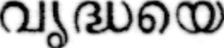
വൃദ്ധയെ
